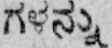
ಗಳನ್ನು
